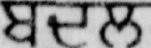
ਬਦਲ
